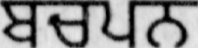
ਬਚਪਨ
